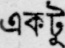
একটু
